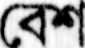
বেশ
